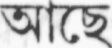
আছে
